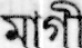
মাগী
